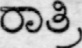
ರಾತ್ರಿ
